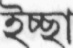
ইচ্ছা
